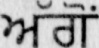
ਅੱਗੋਂ
